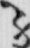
કે
